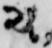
ચ,
